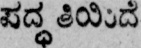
ಪದ್ಧತಿಯಿದೆ.
